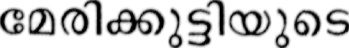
മേരിക്കുട്ടിയുടെ
